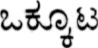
ಒಕ್ಕೂಟ
